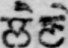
ਲੈਣੇ
